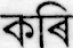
কৰি
